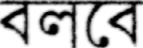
বলবে
